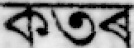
কতৰ
